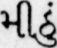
મીઠું
